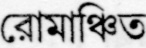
রোমাঞ্চিত
